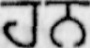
ਹਨ
